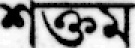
শক্তম
